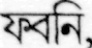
ফবনি,
